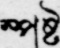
স্পষ্ট
